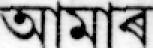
আমাৰ
